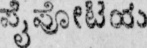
ಪೈಪೋಟಿಯ
